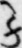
કે
